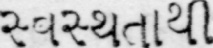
સ્વસ્થતાથી
